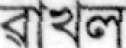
ৱাখল
